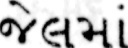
જેલમાં
